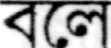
বলে
